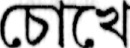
চোখে
